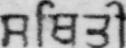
ਸਥਿਤੀ
